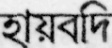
হায়বদি
